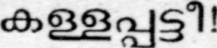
കള്ളപ്പട്ടീ!
